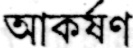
আকর্ষণ
